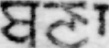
ਬਣਾ
